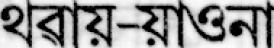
থৱায়-য়াওনা
